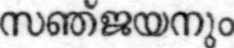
സഞ്ജയനും
